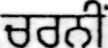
ਚਰਨੀਂ
